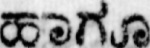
ಹಾಗೂ
